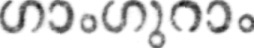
ഗാംഗുറാം
